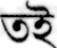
তই
